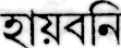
হায়বনি
